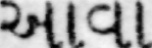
આવા
